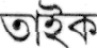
তাইক
